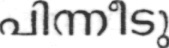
പിന്നീടു
